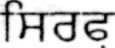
ਸਿਰਫ਼
